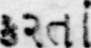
કરતાં
